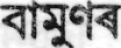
বামুণৰ
